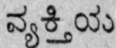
ವ್ಯಕ್ತಿಯ
